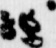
કહું
